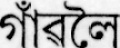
গাঁৱলৈ
